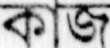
কাজ
